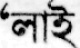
‘লাই
